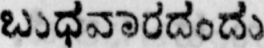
ಬುಧವಾರದಂದು
